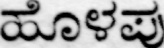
ಹೊಳಪು
